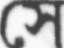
সে
